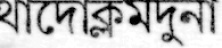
থাদোক্লমদুনা
